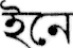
ইনে
